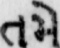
તમે
